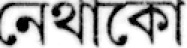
নেথাকো
